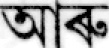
আৰু
